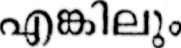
എങ്കിലും
